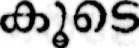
കൂടെ
